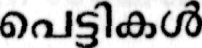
പെട്ടികള്‍
